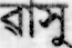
ৱাসু
